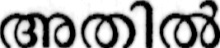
അതില്‍
